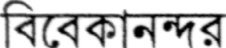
বিবেকানন্দর
